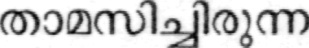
താമസിച്ചിരുന്ന
